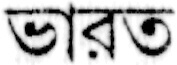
ভারত
